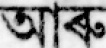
আৰু
